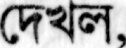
দেখল,
